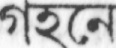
গহনে
